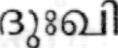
ദുഃഖി
